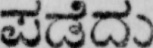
ಪಡೆದು
